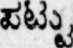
ಪಟ್ಟು
